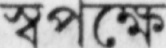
স্বপক্ষে
